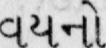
વયનો
